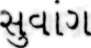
સુવાંગ
